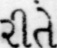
રીતે
